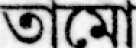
তামো
